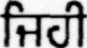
ਜਿਹੀ
